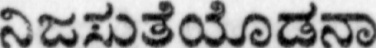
ನಿಜಸುತೆಯೊಡನಾ
